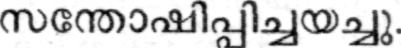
സന്തോഷിപ്പിച്ചയച്ചു.
